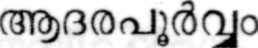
ആദരപൂര്‍വ്വം
